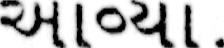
આવ્યા.
